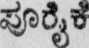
ಪೂರೈಕೆ
